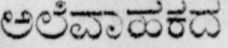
ಅಲೆವಾಹಕದ
